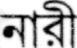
নারী
